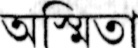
অস্মিতা
